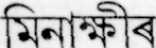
মিনাক্ষীৰ
